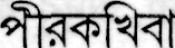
পীরকখিবা
